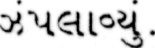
ઝંપલાવ્યું.
